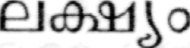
ലക്ഷ്യം
